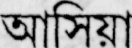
আসিয়া
